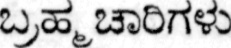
ಬ್ರಹ್ಮಚಾರಿಗಳು
